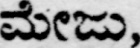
ಮೇಜು,
